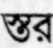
স্তর
